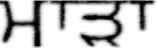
ਮਾੜਾ
